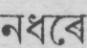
নধৰে
